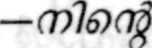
-നിന്റെ
